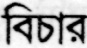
বিচার
